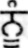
ਨੂੰ
